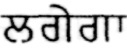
ਲਗੇਗਾ
